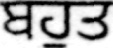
ਬਹੁਤ
